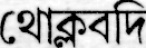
থোক্লবদি
